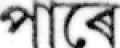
পাৰে
